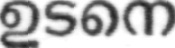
ഉടനെ
